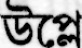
উপ্লে
